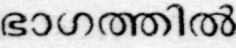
ഭാഗത്തില്‍
